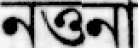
নত্তনা
